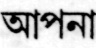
আপনা
